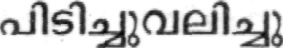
പിടിച്ചുവലിച്ചു
